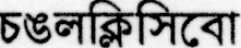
দুকান
